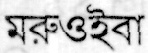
মরুওইবা
